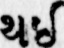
થઈ
